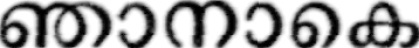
ഞാനാകെ
